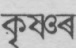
কৃষ্ণৰ
